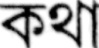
কথা
